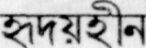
হৃদয়হীন
